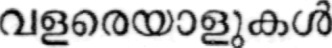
വളരെയാളുകള്‍
